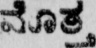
ಮೊತ್ತ
